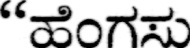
"ಹೆಂಗಸು
